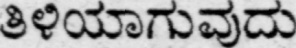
ತಿಳಿಯಾಗುವುದು
